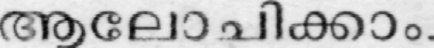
ആലോചിക്കാം.
